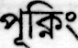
পূক্নিং
